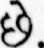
છે.
